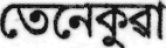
তেনেকুৱা
